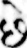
છે
